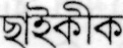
ছাইকীক
